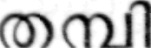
തമ്പി
